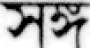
সঙ্গ
